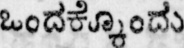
ಒಂದಕ್ಕೊಂದು
